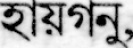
হায়গনু,
